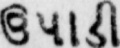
ઉપાડી
